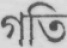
গতি
